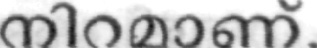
നിറമാണ്.
